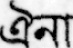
ঐনা
